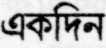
একদিন
